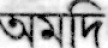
অমদি
